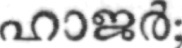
ഹാജര്‍;
